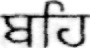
ਬਹਿ
